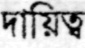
দায়িত্ব
